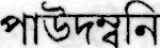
পাউদম্বনি
